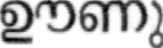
ഊണു
